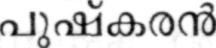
പുഷ്കരന്‍
